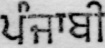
ਪੰਜਾਬੀ
